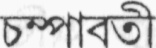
চম্পাবতী
